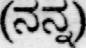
(ನನ್ನ)
